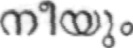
നീയും
